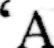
' A
